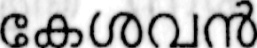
കേശവന്‍
